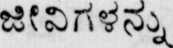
ಜೀವಿಗಳನ್ನು
